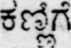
ಕಣ್ಣಿಗೆ
